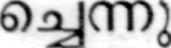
ച്ചെന്നു
